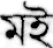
মই
